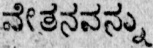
ವೇತನವನ್ನು
